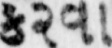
કરવા
